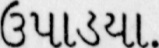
ઉપાડયા.
